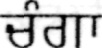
ਚੰਗਾ
